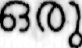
ഒരു
